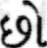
છો
